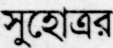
সুহোত্রর
